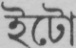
ইটো
